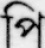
পি
